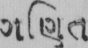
ગણિત
